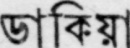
ডাকিয়া
